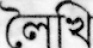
লৈখি
